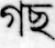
গছ
